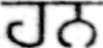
ਹਨ
